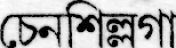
চেনশিল্লগা
